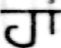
ਹਾਂ
